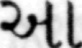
આ
